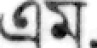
এম.
